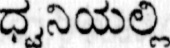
ಧ್ವನಿಯಲ್ಲಿ
